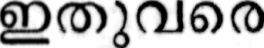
ഇതുവരെ
